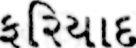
ફરિયાદ
